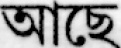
আছে
